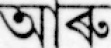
আৰু
